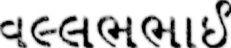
વલ્લભભાઈ
